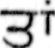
ਤਾਂ
